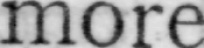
more
